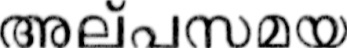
അല്പസമയ
